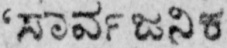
‘ಸಾರ್ವಜನಿಕ
